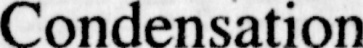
Condensation
